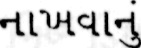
નાખવાનું
